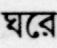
ঘরে
